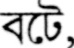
বটে,
